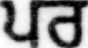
ਪਰ
